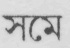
সমে
